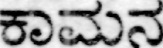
ಕಾಮನ
